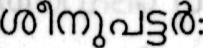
ശീനുപട്ടര്‍:
